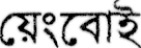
য়েংবোই
